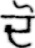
ਦੋ
